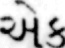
એક
